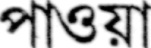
পাওয়া
